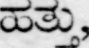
ಹತ್ತು,
